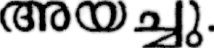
അയച്ചു.
